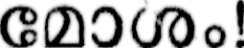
മോശം!
